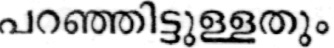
പറഞ്ഞിട്ടുള്ളതും
